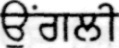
ਉਂਗਲੀ
